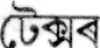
টেক্সৰ
